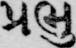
પ્રભુ
